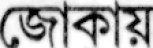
জোকায়
